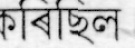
কৰিছিল
